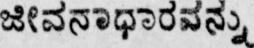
ಜೀವನಾಧಾರವನ್ನು
